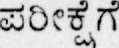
ಪರೀಕ್ಷೆಗೆ
